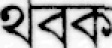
থবক
